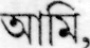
আমি,
